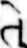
તે
